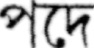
পদে
